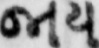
જાય
